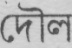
দৌল
